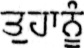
ਤੁਹਾਨੂੰ
